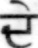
ਦੇ
